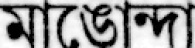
মঙোন্দা
